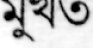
মুখত
